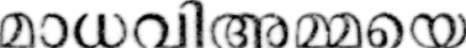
മാധവിഅമ്മയെ
